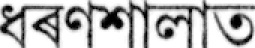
ধৰণশালাত
